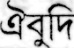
ঐবুদি
